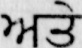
ਅਤੇ
